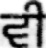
ਵੀ
